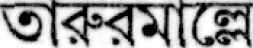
তারুরমাল্লে
